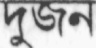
দুজন
